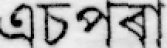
এচপৰা
